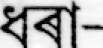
ধৰা-
